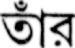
তাঁর
